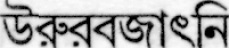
উরুরবজাৎনি
